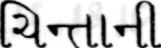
ચિન્તાની
